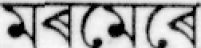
মৰমেৰে
